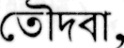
তৌদবা,
